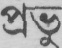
প্ৰভু
